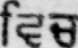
ਵਿਚ
